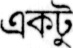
একটু
